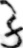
કે
